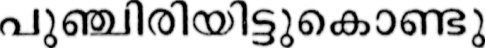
പുഞ്ചിരിയിട്ടുകൊണ്ടു
